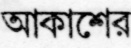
আকাশের
